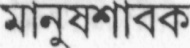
মানুষশাবক
